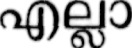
എല്ലാ
